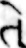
તે
